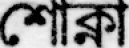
শোক্না
